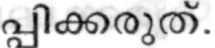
പ്പിക്കരുത്.
